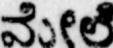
ಮೇಲೆ
